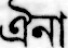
ঐনা
